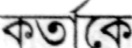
কর্তাকে
